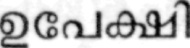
ഉപേക്ഷി
